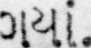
ગયાં.
